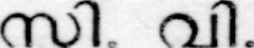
സി.വി.
